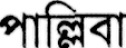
পাল্লিবা
